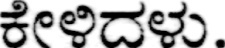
ಕೇಳಿದಳು.
